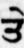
ਤੇ
